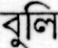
বুলি
